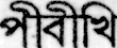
পীবীখি
